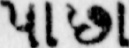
પાછા
